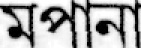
মপানা
